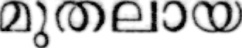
മുതലായ
